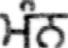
ਮੰਨ
